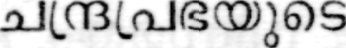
ചന്ദ്രപ്രഭയുടെ
